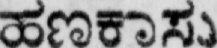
ಹಣಕಾಸು
